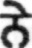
ਨੇ
